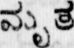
ಮೃತ
